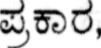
ಪ್ರಕಾರ,
